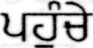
ਪਹੁੰਚੇ
